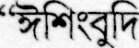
“ঈশিংবুদি
